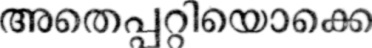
അതെപ്പറ്റിയൊക്കെ
